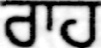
ਰਾਹ
